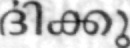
ദിക്കു
